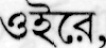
ওইরে,
